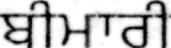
ਬੀਮਾਰੀ
